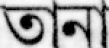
তানা
